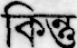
কিন্তু
